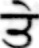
ਤੇ
